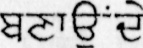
ਬਣਾਉਂਦੇ
